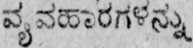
ವ್ಯವಹಾರಗಳನ್ನು
